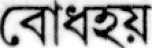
বোধহয়
